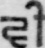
ਵੀ
